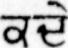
ਕਦੇ
